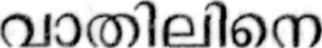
വാതിലിനെ
